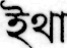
ইথা
